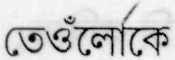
তেওঁলোকে
